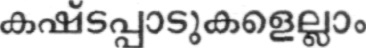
കഷ്ടപ്പാടുകളെല്ലാം
